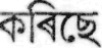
কৰিছে
